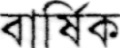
বার্ষিক
